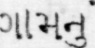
ગામનું
